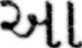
આ
